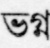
ভগ্ন
